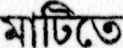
মাটিতে
